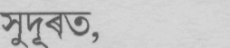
সুদূৰত,
